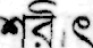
শরীৎ
